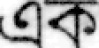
এক
